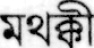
মথক্কী
